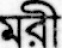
মরী
